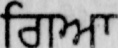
ਗਿਆ
